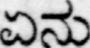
ಏನು
